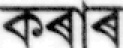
কৰাৰ
